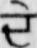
ਦੇ
